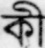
কী
